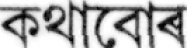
কথাবোৰ
